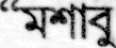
“মশাবু
